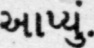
આપ્યું.
